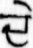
ਦੇ
